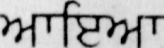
ਆਇਆ
